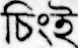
চিংই
